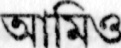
আমিও
